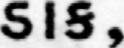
ડાક,
